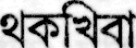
থকখিবা
